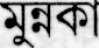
মুন্নকা
